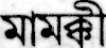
মামক্কী
